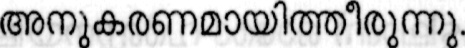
അനുകരണമായിത്തീരുന്നു.
